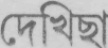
দেখিছা
